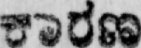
ಕಾರಣ
